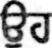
ਉਹ
